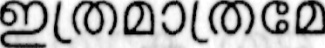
ഇത്രമാത്രമേ
